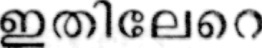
ഇതിലേറെ
